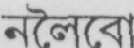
নলৈবো
